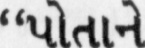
"પોતાને
